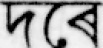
দৰে
